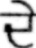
ਦੇ
